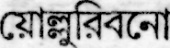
য়োল্লুরিবনো
